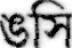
ঙসি
